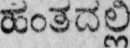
ಹಂತದಲ್ಲಿ
